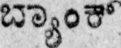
ಬ್ಯಾಂಕ್
